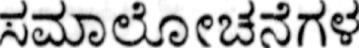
ಸಮಾಲೋಚನೆಗಳ
